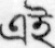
এই
